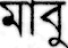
মাবু
